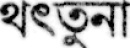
থৎতুনা
